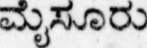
ಮೈಸೂರು
